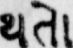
થતો
